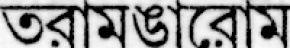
তরামঙোরোম
